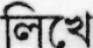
লিখে
